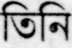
তিনি
